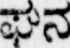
ಘನ
